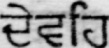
ਦੇਵਹਿ
